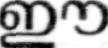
ഈ
